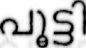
പൂട്ടി
